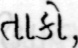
તાકો
